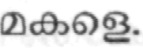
മകളെ.
